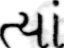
ત્યાં
